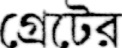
গ্রেটের
